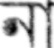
না
